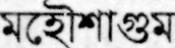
মহৌশাগুম
